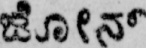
ಜೋನ್
